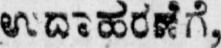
ಉದಾಹರಣೆಗೆ,
